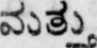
ಮತ್ತು
